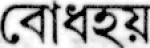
বোধহয়
